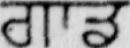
ਗਾਡ
